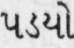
પડયો
